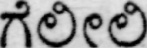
ಗೆಲೀಲಿ
